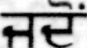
ਜਦੋਂ
